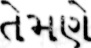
તેમણે
